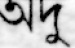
অদু
